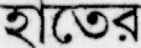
হাতের
